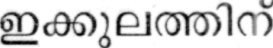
ഇക്കുലത്തിന്
